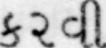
કરવી
